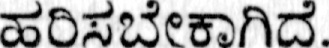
ಹರಿಸಬೇಕಾಗಿದೆ.
